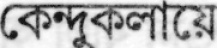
কেন্দুকলায়ে
